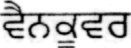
ਵੈਨਕੂਵਰ
